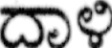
ದಾಳಿ
